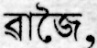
ৱাজৈ,
